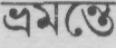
ভ্ৰমন্তে
